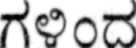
ಗಳಿಂದ
